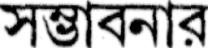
সম্ভাবনার
